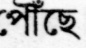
পৌঁছে
